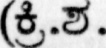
(ಕ್ರಿ.ಶ.
